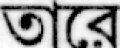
তারে
